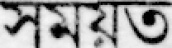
সময়ত
